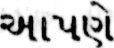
આપણે
